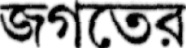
জগতের
